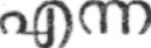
എന്ന
